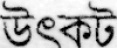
উৎকট
